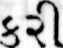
કરી
